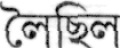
লৈছিল
